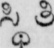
ಸ್ಥಿತಿ
